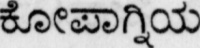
ಕೋಪಾಗ್ನಿಯ
